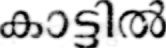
കാട്ടില്‍
